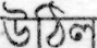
উঠিল
